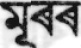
মূৰৰ
